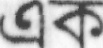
এক
